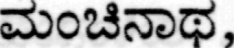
ಮಂಚಿನಾಥ
